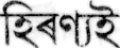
হিৰণ্যই
